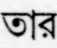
তার
